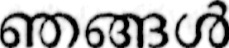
ഞങ്ങള്‍
